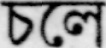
চলে
